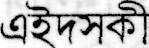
এইদসকী
